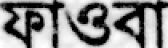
ফাওবা
